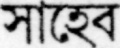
সাহেব
